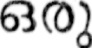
ഒരു
